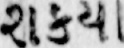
શક્યા
